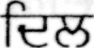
ਦਿਲ
